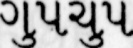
ગુપચુપ
